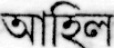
আহিল
